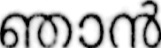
ഞാന്‍
